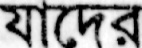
যাদের
